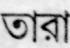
তারা
